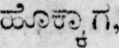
ಹೊಕ್ಕಾಗ,
